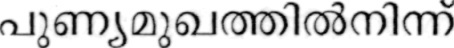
പുണ്യമുഖത്തില്‍നിന്ന്
